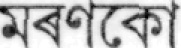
মৰণকো
